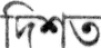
দিশত
